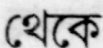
থেকে
